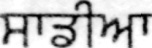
ਸਾਡੀਆ
